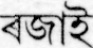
ৰজাই
